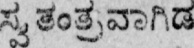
ಸ್ವತಂತ್ರವಾಗಿಡ
